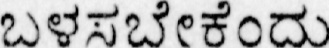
ಬಳಸಬೇಕೆಂದು
